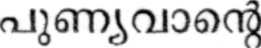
പുണ്യവാന്റെ
